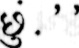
છું."
